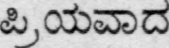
ಪ್ರಿಯವಾದ
